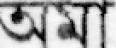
অমা
